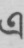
এ
